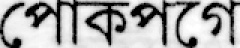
পোকপগে
